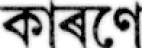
কাৰণে
